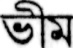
ভীম
